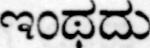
ಇಂಥದು
